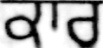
ਕਾਰ
